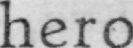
hero
